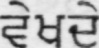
ਵੇਖਦੇ
